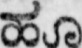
ಹೂ
